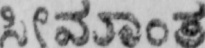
ಸೀಮಾಂತ
